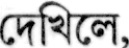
দেখিলে,
